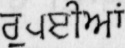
ਰੁਪਈਆਂ
